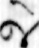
જે
